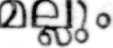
മല്ലും
